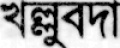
খল্লুবদা
